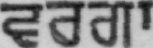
ਵਰਗਾ
